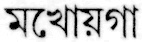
মখোয়গা
